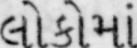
લોકોમાં
